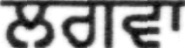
ਲਗਵਾ
